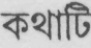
কথাটি
